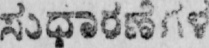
ಸುಧಾರಣೆಗಳ
